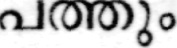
പത്തും
